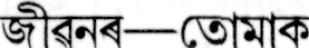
জীৱনৰ-তোমাক
